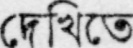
দেখিতে
